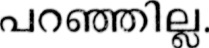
പറഞ്ഞില്ല.
